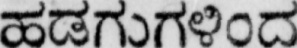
ಹಡಗುಗಳಿಂದ
